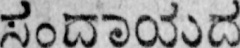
ಸಂದಾಯದ
